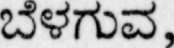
ಬೆಳಗುವ,
